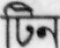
টিন
